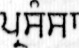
ਪ੍ਰਸੰਸਾ
